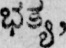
ಭತ್ಯ,
